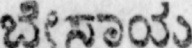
ಬೇಸಾಯ
